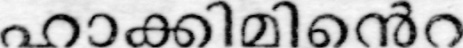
ഹാക്കിമിന്റെ
